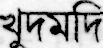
খুদমদি
